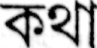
কথা
